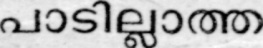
പാടില്ലാത്ത
